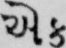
એક
